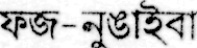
ফজ-নুঙাইবা
